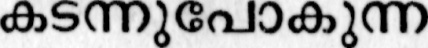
കടന്നുപോകുന്ന
